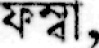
ফম্বা,
